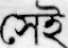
সেই
